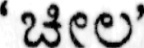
‘ಚೀಲ'
